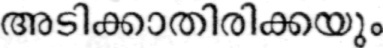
അടിക്കാതിരിക്കയും
